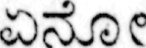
ಏನೋ
